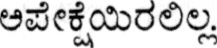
ಅಪೇಕ್ಷೆಯಿರಲಿಲ್ಲ.
